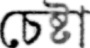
চেষ্টা
